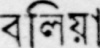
বলিয়া
